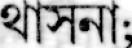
থাসনা;
